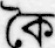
কৈ
